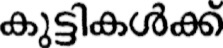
കുട്ടികള്‍ക്ക്
